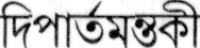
দিপার্তমন্তকী
